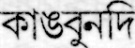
কাঙবুনদি
